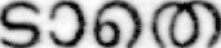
ടാതെ
